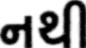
નથી
